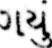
ગયું
